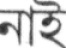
নাই
